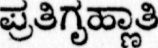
ಪ್ರತಿಗೃಹ್ಣಾತಿ
